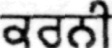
ਕਰਨੀ
